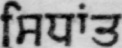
ਸਿਧਾਂਤ
